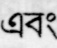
এবং
